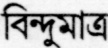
বিন্দুমাত্র
